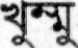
খুম্মু
